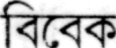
বিবেক
